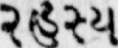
રહસ્ય
